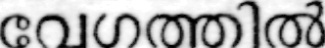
വേഗത്തില്‍
